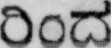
ರಿಂದ
